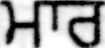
ਮਾਰ
